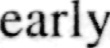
early
